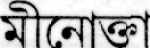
মীনোক্তা
